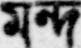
মন্দ
